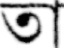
তা
